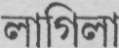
লাগিলা
